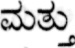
ಮತ್ತು
